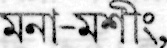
মনা-মশীং,
